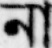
না
